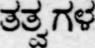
ತತ್ವಗಳ
